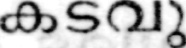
കടവു
